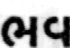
ભવ
